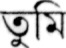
তুমি
